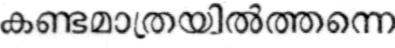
കണ്ടമാത്രയില്‍ത്തന്നെ
